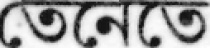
তেনেতে
